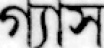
গ্যাস
